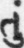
તું
